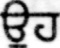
ਉਹ
